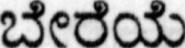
ಬೇರೆಯೆ
